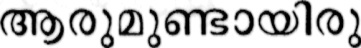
ആരുമുണ്ടായിരു
